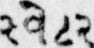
સ્વેટર
